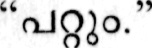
“പറ്റും”
